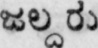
ಜಲ್ದರು
